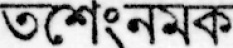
তশেংনমক
